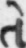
તે
